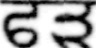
ਫੜ
